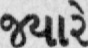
જ્યારે
